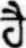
ਹੈ
